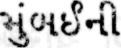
મુંબઈની
